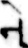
ને
